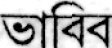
ভাবিব
